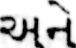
અને
